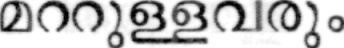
മററുള്ളവരും
